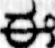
ಈ
